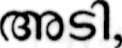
അടി,
